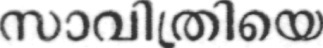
സാവിത്രിയെ
